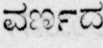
ವರ್ಣದ
